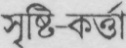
সৃষ্টি-কৰ্ত্তা
